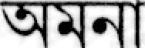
অমনা
